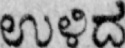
ಉಳಿದ
